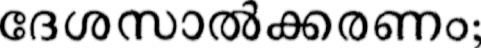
ദേശസാല്‍ക്കരണം;
